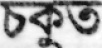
চকুত
